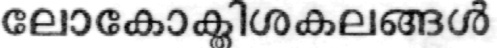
ലോകോക്തിശകലങ്ങള്‍
